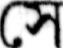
সে
